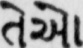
તેઓ
